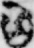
છે
